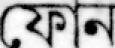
ফোন
